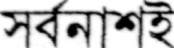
সর্বনাশই
